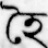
হৈ
